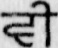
ਵੀ
